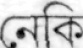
নেকি
